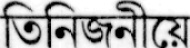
তিনিজনীয়ে
